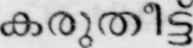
കരുതീട്ട്
